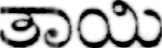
ತಾಯಿ
